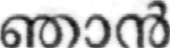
ഞാന്‍
